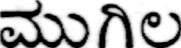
ಮುಗಿಲ
